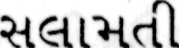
સલામતી
